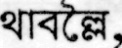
থাবল্লৈ,
